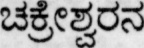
ಚಕ್ರೇಶ್ವರನ
